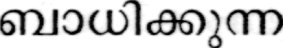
ബാധിക്കുന്ന
